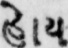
હોય
